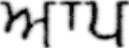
ਆਪ
